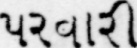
પરવારી
